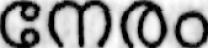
നേരം
